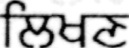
ਲਿਖਣ
